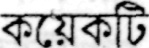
কয়েকটি
